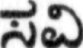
ಸವಿ
